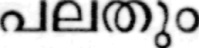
പലതും
